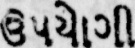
ઉપયોગી
